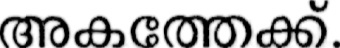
അകത്തേക്ക്.
